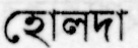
হোলদা
